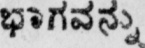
ಭಾಗವನ್ನು
